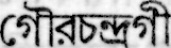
গৌরচন্দ্রগী
